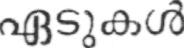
ഏടുകള്‍
